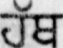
ਹੱਥ
